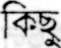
কিছু
